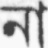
না
